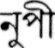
নুপী
